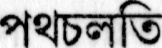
পথচলতি
